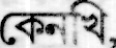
কেনখি,
